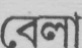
বেলা
